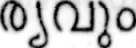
ര്യവും
